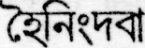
হৈনিংদবা
